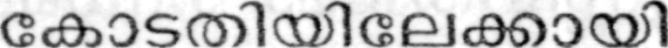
കോടതിയിലേക്കായി
